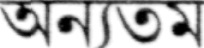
অন্যতম
